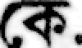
কে
